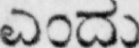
ಎಂದು
